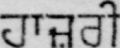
ਹਾਜ਼ਰੀ
